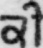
ਕੀ
